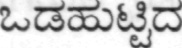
ಒಡಹುಟ್ಟಿದ
